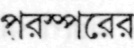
পরস্পরের
